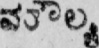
ಮೌಲ್ಯ
